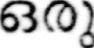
ഒരു
